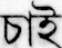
চাই
